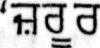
'ਜ਼ਰੂਰ
